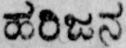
ಹರಿಜನ
